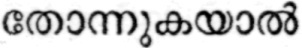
തോന്നുകയാല്‍
